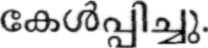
കേള്‍പ്പിച്ചു.
